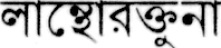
মথং
